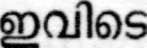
ഇവിടെ
